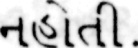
નહોતી.
